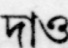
দাও
